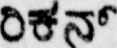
ರಿಕನ್
